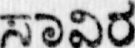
ಸಾವಿರ
